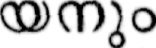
യനും
